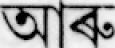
আৰু
